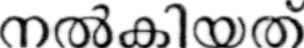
നല്‍കിയത്
